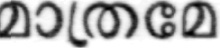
മാത്രമേ
